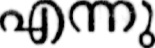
എന്നു
